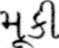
મૂકી
